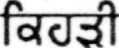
ਕਿਹੜੀ
